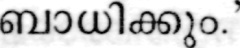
ബാധിക്കും.’
